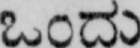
ಒಂದು
